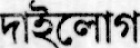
দাইলোগ
